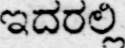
ಇದರಲ್ಲಿ
